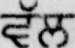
ਵੱਲ
